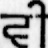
ਵੀ
